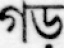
গড়
